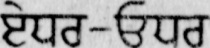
ਏਧਰ-ਓਧਰ
